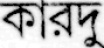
কারদু
